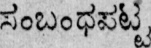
ಸಂಬಂಧಪಟ್ಟ
